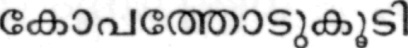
കോപത്തോടുകൂടി
